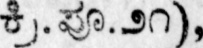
ಕ್ರಿ.ಪೂ.೨೧),
